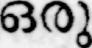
ഒരു
